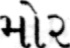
મોર
